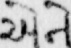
એને
